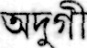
অদুগী
